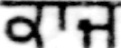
ਕਾਜ
